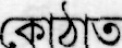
কোঠাত
